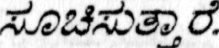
ಸೂಚಿಸುತ್ತಾರೆ.
